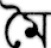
মৈ
